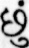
છું
